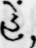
હેં,
